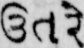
ઉતરે
